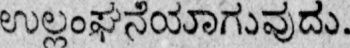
ಉಲ್ಲಂಘನೆಯಾಗುವುದು.
